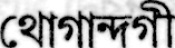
থোগান্দগী
